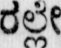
ರಲ್ಲೇ
